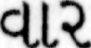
વાર
